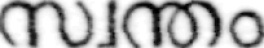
സ്വന്തം
